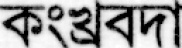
কংখ্রবদা
